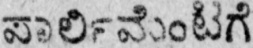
ಪಾರ್ಲಿಮೆಂಟಿಗೆ
